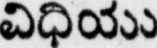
ವಿಧಿಯು
